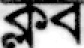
ক্লব
